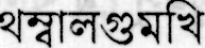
থম্বালগুমখি
